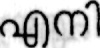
എനി
